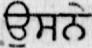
ਉਸਨੇ
